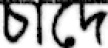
চাদে
